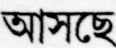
আসছে
